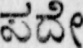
ಪದೇ
